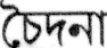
চৈদনা
